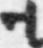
ન
